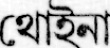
থোইনা
